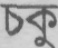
চকু
